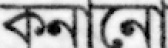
কনানো
